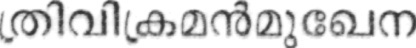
ത്രിവിക്രമന്‍മുഖേന
